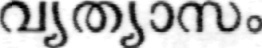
വ്യത്യാസം
